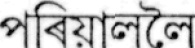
পৰিয়াললৈ
